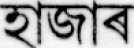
হাজাৰ
